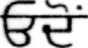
ਓਦੋਂ
